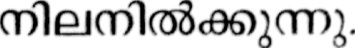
നിലനില്‍ക്കുന്നു.
